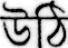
উঠি
